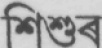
শিশুৰ
